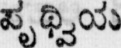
ಪೃಥ್ವಿಯ
